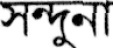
সন্দুনা
